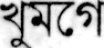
খু্মগে
